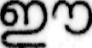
ഈ
